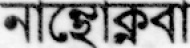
নান্থোক্নবা
